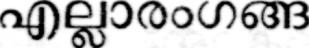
എല്ലാരംഗങ്ങ
